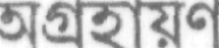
অগ্রহায়ণ
